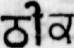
ਠੀਕ
